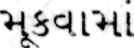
મૂકવામાં
